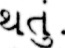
થતું.
